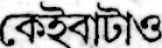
কেইবাটাও
